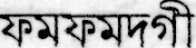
ফমফমদগী
